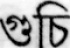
গুচি
